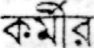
কর্মীর
